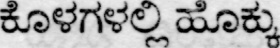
ಕೊಳಗಳಲ್ಲಿಹೊಕ್ಕು
